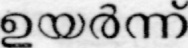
ഉയര്‍ന്ന്
